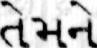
તેમને
